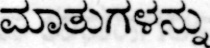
ಮಾತುಗಳನ್ನು
